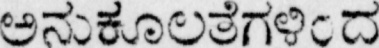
ಅನುಕೂಲತೆಗಳಿಂದ
